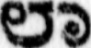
ಲಾ
